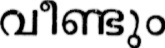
വീണ്ടും
